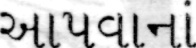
આપવાનાં
